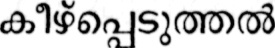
കീഴ്പ്പെടുത്തല്‍
